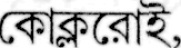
কোক্লরোই,
